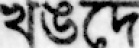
খঙদে
